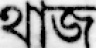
থাজ
